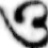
ও
